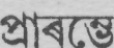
প্রাৰম্ভে
